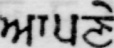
ਆਪਣੇ
